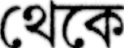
থেকে
